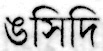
ঙসিদি
